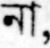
না,
